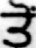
ਤੋਂ
